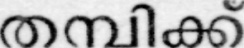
തമ്പിക്ക്
